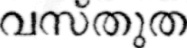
വസ്തുത
